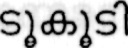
ടുകൂടി
